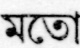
মতো
